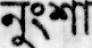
নুংশা
